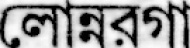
লোন্নরগা
